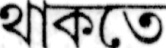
থাকতে
